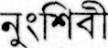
নুংশিবী
